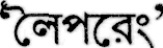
‘লৈপরেং’
